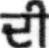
ਦੀ
